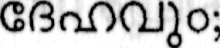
ദേഹവും;
